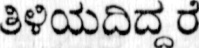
ತಿಳಿಯದಿದ್ದರೆ
